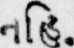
નહિ.
